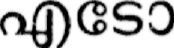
എടോ
